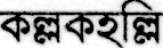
কল্লকহল্লি
